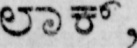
ಲಾಕ್,
